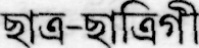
ছাত্র-ছাত্রিগী
